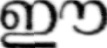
ഈ
